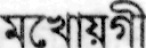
মখোয়গী
